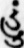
હું
